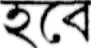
হবে
